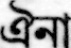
ঐনা
